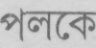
পলকে
